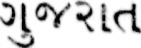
ગુજરાત
